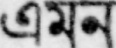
এমন
